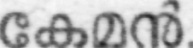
കേമന്‍.
